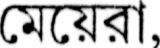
মেয়েরা,
